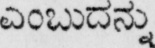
ಎಂಬುದನ್ನು
